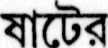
ষাটের
